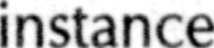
instance
